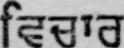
ਵਿਚਾਰ
